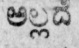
ಅಲ್ಲದೆ
